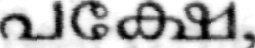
പക്ഷേ,
